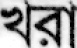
খরা
